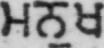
ਮਨੁਖ
